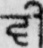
ਵੀ
